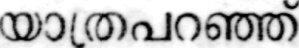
യാത്രപറഞ്ഞ്
